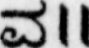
ವ||
